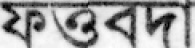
ফত্তবদা
